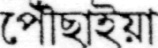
পৌঁছাইয়া
